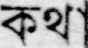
কথা
